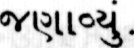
જણાવ્યું.
